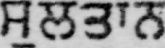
ਸੁਲਤਾਨ
